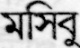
মসিবু
